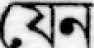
যেন
